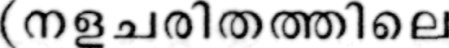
(നളചരിതത്തിലെ
